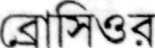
ব্রোসিওর
